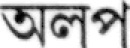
অলপ
